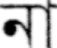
না
